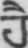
ਹੈ
